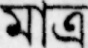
মাত্র
